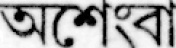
অশেংবা
